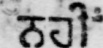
ਨਹੀਂ
